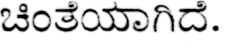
ಚಿಂತೆಯಾಗಿದೆ.
